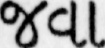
જવા
